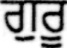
ਗੁਰੂ
